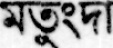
মতুংদা
